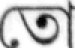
তো
